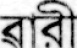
ৱারী
